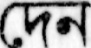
দেন
